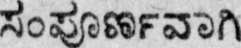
ಸಂಪೂರ್ಣವಾಗಿ
